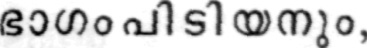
ഭാഗംപിടിയനും,
